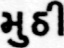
મુઠી
